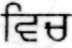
ਵਿਚ
